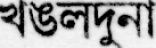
খঙলদুনা
